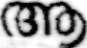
ആ
